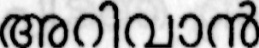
അറിവാന്‍
